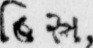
હિસ્ત્ર,
